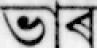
ভাৰ
